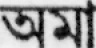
অমা
